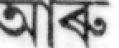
আৰু
